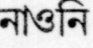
নাওনি
